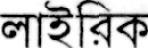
লাইরিক
